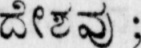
ದೇಶವು;
